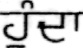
ਹੁੰਦਾ
